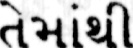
તેમાંથી
